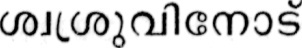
ശ്വശ്രുവിനോട്
